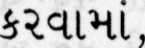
કરવામાં,
